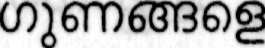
ഗുണങ്ങളെ
